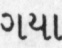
ગયા
